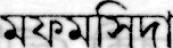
মফমসিদা
